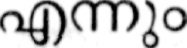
എന്നും
